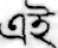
এই
